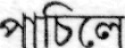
পাচিলে
